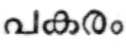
പകരം
